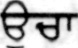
ਉਚਾ
